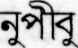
নুপীবু
